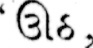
ઊઠ,
